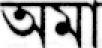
অমা
